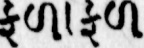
ફળાફળ
